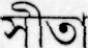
সীতা
